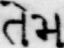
તેમ
